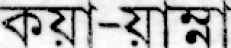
কয়া-য়াম্না
